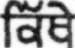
ਕਿੱਥੇ
